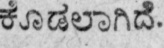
ಕೊಡಲಾಗಿದೆ.
